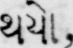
થયો,
